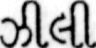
ઝીલી
